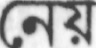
নেয়
